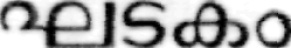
ഘടകം
